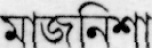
মাজনিশা
